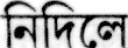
নিদিলে
